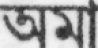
অমা
